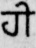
ਹੀ
